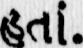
હતાં.
